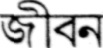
জীবন
